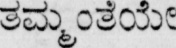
ತಮ್ಮಂತೆಯೇ
